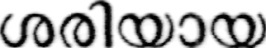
ശരിയായ
